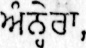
ਅੰਨ੍ਹੇਰਾ,
